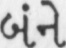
બંને
